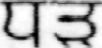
ਧੜ
